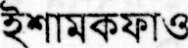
ইশামকফাও
